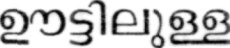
ഊട്ടിലുള്ള
